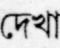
দেখা
